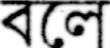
বলে
